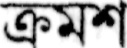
ক্রমশ
